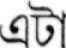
এটা
